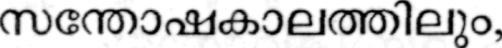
സന്തോഷകാലത്തിലും,
